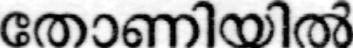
തോണിയില്‍
